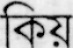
কিয়
